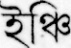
ইঞ্চি
